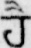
ਹੈ
